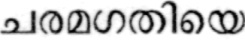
ചരമഗതിയെ
